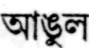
আঙুল
